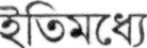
ইতিমধ্যে
